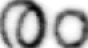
രം
